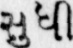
સુધી
